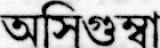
অসিগুম্বা
